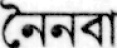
নৈনবা
